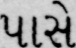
પાસે
